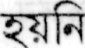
হয়নি
